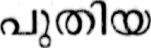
പുതിയ
